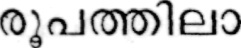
രൂപത്തിലാ
